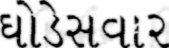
ઘોડેસવાર
